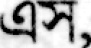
এস,
